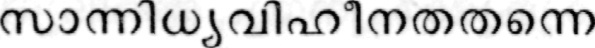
സാന്നിധ്യവിഹീനതതന്നെ
